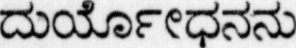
ದುರ್ಯೋಧನನು
